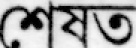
শেষত
